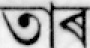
তাৰ
